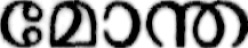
മോന്ത
